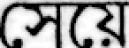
সেয়ে
